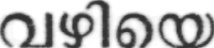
വഴിയെ
